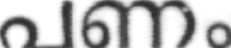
പണം
